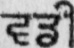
ਵਡੀ
